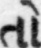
તો
